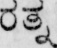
ರತ್ನ
